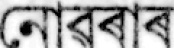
নোৱৰাৰ
